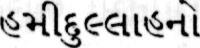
હમીદુલ્લાહનો
